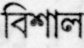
বিশাল
